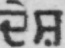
ਦੇਸ਼
